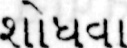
શોધવા
